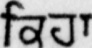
ਕਿਹਾ
